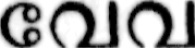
വേവ
